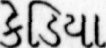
કેડિયા
